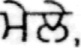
ਮੇਲੇ,
